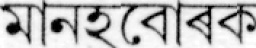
মানহবোৰক
